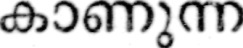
കാണുന്ന
